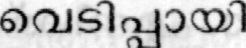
വെടിപ്പായി
